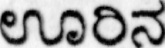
ಊರಿನ
